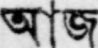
আজ
